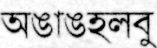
অঙাঙহলবু
